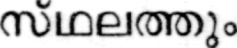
സ്ഥലത്തും
